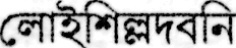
লোইশিল্লদবনি
